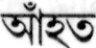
আঁহত
